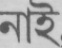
নাই,
